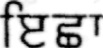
ਇਛਾ
